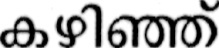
കഴിഞ്ഞ്
